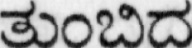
ತುಂಬಿದ
